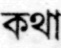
কথা
